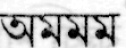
অমমম
